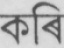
কৰি
